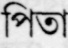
পিতা
